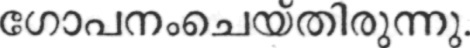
ഗോപനംചെയ്തിരുന്നു.
